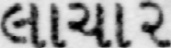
લાચાર
